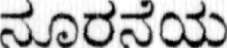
ನೂರನೆಯ
